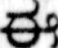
ಈ
